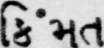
કિંમત
